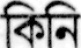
কিনি
